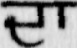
ਦਾ
